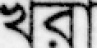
খরা
